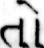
તો
